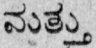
ಮತ್ತು
